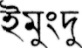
ইমুংদু
